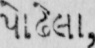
પોઢેલા,
